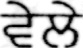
ਵੇਲੇ
